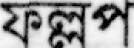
ফল্লপ
